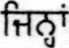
ਜਿਨ੍ਹਾਂ
